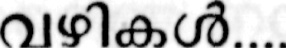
വഴികള്‍....
